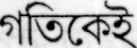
গতিকেই
